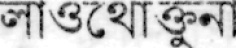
লাওথোক্তুনা
